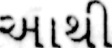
આથી
